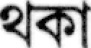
থকা
